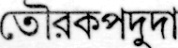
তৌরকপদুদা
